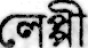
লেপ্পী
